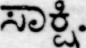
ಸಾಕ್ಷಿ.
